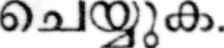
ചെയ്യുക.
